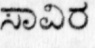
ಸಾವಿರ
